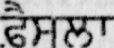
ਫ਼ੈਸਲਾ
